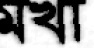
মখা
